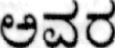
ಅವರ
